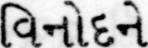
વિનોદને
